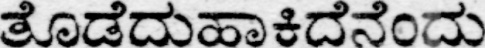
ತೊಡೆದುಹಾಕಿದೆನೆಂದು
